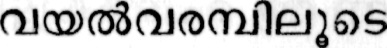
വയല്‍വരമ്പിലൂടെ
